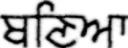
ਬਣਿਆ
